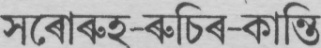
সৰোৰুহ-ৰুচিৰ-কান্তি
